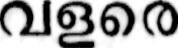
വളരെ
